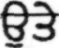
ਉਤੇ
